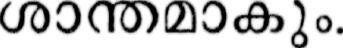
ശാന്തമാകും.
